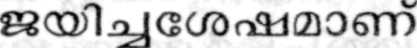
ജയിച്ചശേഷമാണ്
